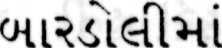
બારડોલીમાં
